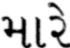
મારે
